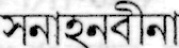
সনাহনবীনা
